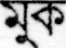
মুক
